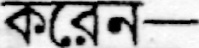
করেন—
